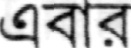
এবার
